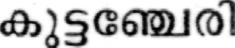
കുട്ടഞ്ചേരി
